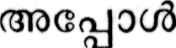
അപ്പോള്‍
